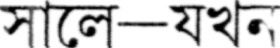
সালে–যখন
